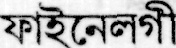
ফাইনেলগী
